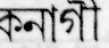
কনাগী
